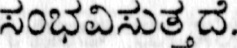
ಸಂಭವಿಸುತ್ತದೆ.
